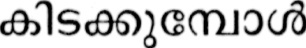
കിടക്കുമ്പോള്‍
